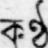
কণ্ঠ
